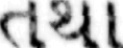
તથા
